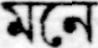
মনে
